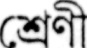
শ্রেণী
